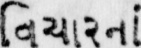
વિચારનાં
